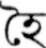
হৈ
